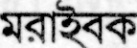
মরাইবক
